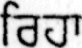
ਰਿਹਾ
